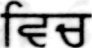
ਵਿਚ
